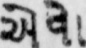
એવો
